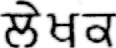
ਲੇਖਕ
